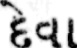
દેવા
